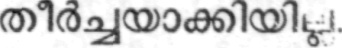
തീര്‍ച്ചയാക്കിയില്ല.
